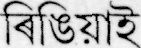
ৰিঙিয়াই
